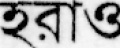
হরাও
